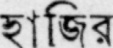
হাজির
